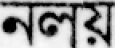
নলয়
